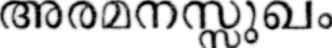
അരമനസ്സുഖം
